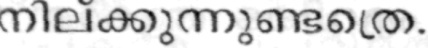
നില്ക്കുന്നുണ്ടത്രെ.
